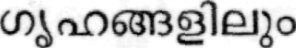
ഗൃഹങ്ങളിലും
